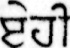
ਏਹੀ
